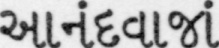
આનંદવાજાં
